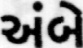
અંબે
